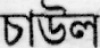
চাউল
